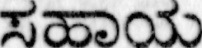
ಸಹಾಯ
